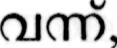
വന്ന്,
